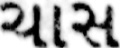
ચાસ
